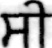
ਸੀ
